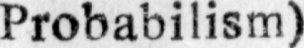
Probabilism)
